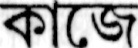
কাজে
